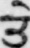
ਤੇ
